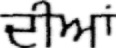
ਦੀਆਂ
